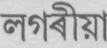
লগৰীয়া
